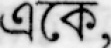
একে,
